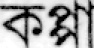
কপ্পা
